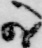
જે
